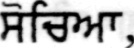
ਸੋਚਿਆ,
